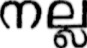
നല്ല
